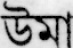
উমা
